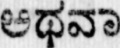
ಅಥವಾ
